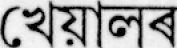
খেয়ালৰ
